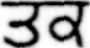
ਤਕ
